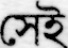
সেই
